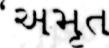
'અમૃત
